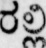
ರಲ್ಲಿ
